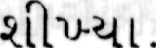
શીખ્યા.
